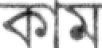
কাম
